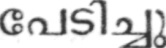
പേടിച്ചു
